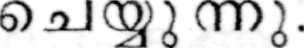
ചെയ്യുന്നു.
